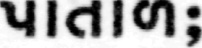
પાતાળ;
